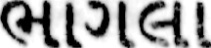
ભાગલા
